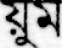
য়ুম
